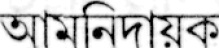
আমনিদায়ক
